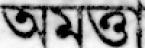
অমত্তা
